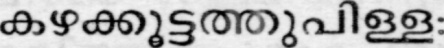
കഴക്കൂട്ടത്തുപിള്ള:
